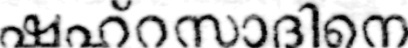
ഷഹ്റസാദിനെ
